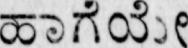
ಹಾಗೆಯೇ
